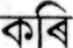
কৰি
